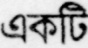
একটি
